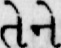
તેને
